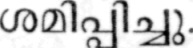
ശമിപ്പിച്ചു.
